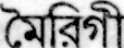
মৈরিগী
